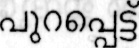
പുറപ്പെട്ട്
